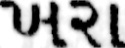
ખરા
